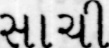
સાચી
